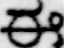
ಈ
